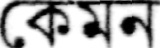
কেমন
